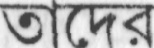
তাদের
